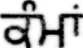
ਕੰਮਾਂ
